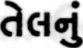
તેલનું
